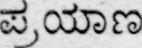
ಪ್ರಯಾಣ
